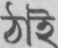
ঠাই
